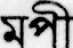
মপী
